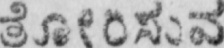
ತೋರಿಸುವ
